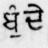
ਬੁੰਦੇ
